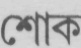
শোক
